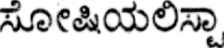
ಸೋಷಿಯಲಿಸ್ಟಾ
